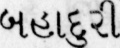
બહાદુરી
